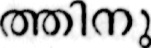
ത്തിനു
